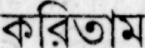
করিতাম
